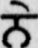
ਨੇ
